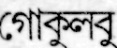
গোকুলবু
